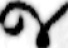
જ
